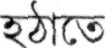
হঠাতে
